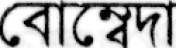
বোম্বেদা
